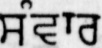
ਸੰਵਾਰ
